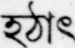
হঠাৎ
